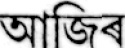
আজিৰ
